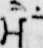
ਮੈਂ
